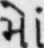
મોં
